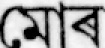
মোৰ
